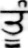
ਤੂੰ
